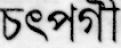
চৎপগী
